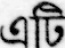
এটি
